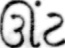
ઊંટ
